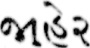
જાહેર
